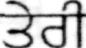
ਤੇਰੀ
